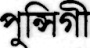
পুন্সিগী
